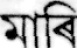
মাৰি
